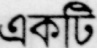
একটি
